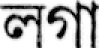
লগা
